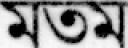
মতম
